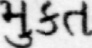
મુકત
